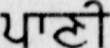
ਪਾਣੀ
